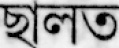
ছালত
